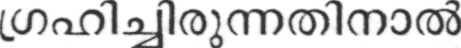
ഗ്രഹിച്ചിരുന്നതിനാല്‍
